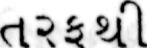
તરફથી
